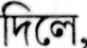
দিলে,
